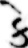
કે
